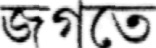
জগতে
